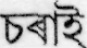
চৰাই
